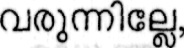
വരുന്നില്ലേ,
